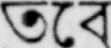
তবে
